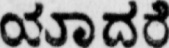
ಯಾದರೆ
